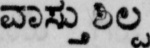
ವಾಸ್ತುಶಿಲ್ಪ
